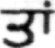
ਤਾਂ
